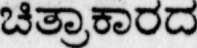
ಚಿತ್ರಾಕಾರದ
